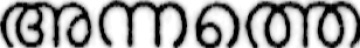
അന്നത്തെ
